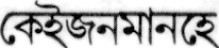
কেইজনমানহে
